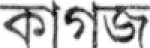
কাগজ
